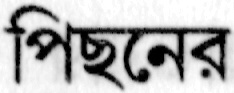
পিছনের
